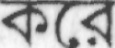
করে
